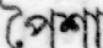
পৈশা
